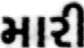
મારી
